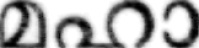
മഹാ
